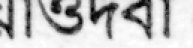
য়াওদবা
